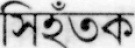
সিহঁতক
